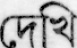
দেখি
